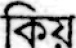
কিয়
